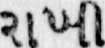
રાખી
